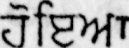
ਹੋਇਆ
